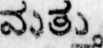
ಮತ್ತು
